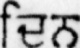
ਦਿਨ
